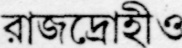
রাজদ্রোহীও
